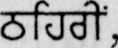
ਠਹਿਰੀਂ,
